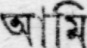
আমি
